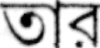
তার
